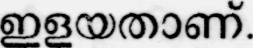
ഇളയതാണ്.
